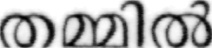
തമ്മില്‍
